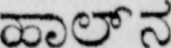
ಹಾಲ್‌ನ
